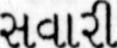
સવારી
